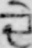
ਦੇ
